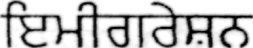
ਇਮੀਗਰੇਸ਼ਨ
